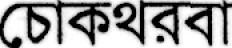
চোকথরবা
